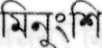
মিনুংশি
